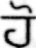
ਹੋ
